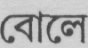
বোলে
